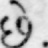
છે.
